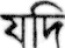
যদি
